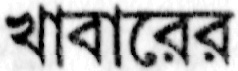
খাবারের
